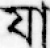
যা
